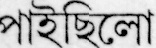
পাইছিলো
